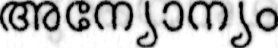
അന്യോന്യം
